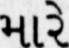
મારે
